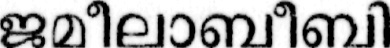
ജമീലാബീബി
